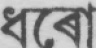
ধৰো
